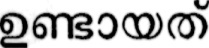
ഉണ്ടായത്
